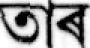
তাৰ
